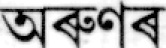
অৰুণৰ
